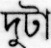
দুটা
